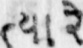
ત્યારે
